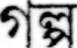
গল্প
